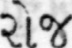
રોજ
